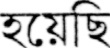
হয়েছি
